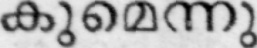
കുമെന്നു
